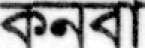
কনবা
